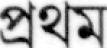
প্রথম
